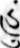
હું
